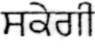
ਸਕੇਗੀ
